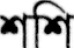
শশি
